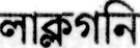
লাক্লগনি
